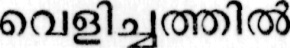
വെളിച്ചത്തില്‍
